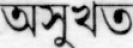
অসুখত
